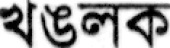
খঙলক
